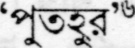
‘পুতহুর’৬
